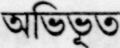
অভিভূত
